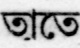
তাতে
